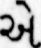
એ
